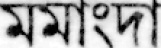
মমাংদা
